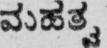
ಮಹತ್ವ
